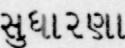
સુધારણા
